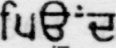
ਪਿਉਂਦ
